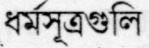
ধর্মসূত্রগুলি
